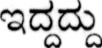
ಇದ್ದದ್ದು
